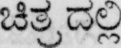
ಚಿತ್ರದಲ್ಲಿ
